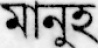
মানুহ
